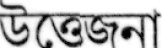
উত্তেজনা
